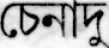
চেনাদু
